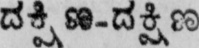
ದಕ್ಷಿಣ-ದಕ್ಷಿಣ
